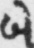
બે
